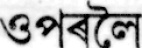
ওপৰলৈ
